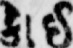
કોઈ
